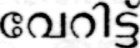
വേറിട്ട്
